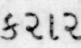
કરાર
